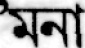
’মনা
